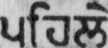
ਪਹਿਲੇ
